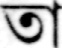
তা
